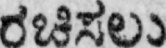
ರಚಿಸಲು
